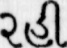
રહી
